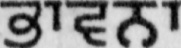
ਭਾਵਨਾ
